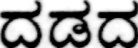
ದಡದ
